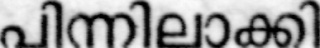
പിന്നിലാക്കി
